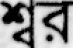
শ্বর
